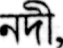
নদী,
